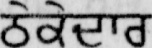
ਠੇਕੇਦਾਰ
